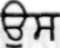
ਉਸ
